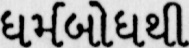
ધર્મબોધથી
